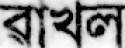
ৱাখল
